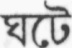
ঘটে
